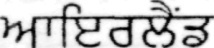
ਆਇਰਲੈਂਡ
